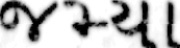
જમ્યા
